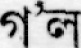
গ'ল
